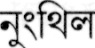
নুংথিল
